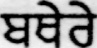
ਬਥੇਰੇ
